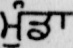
ਮੁੰਡਾ
